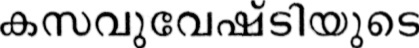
കസവുവേഷ്ടിയുടെ
